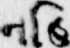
નહિ
